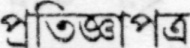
প্রতিজ্ঞাপত্র
